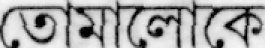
তোমালোকে
